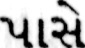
પાસે
